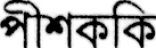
পীশককি
